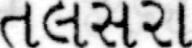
તલસરા
